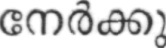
നേര്‍ക്കു
